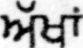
ਅੱਖਾਂ
